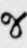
જ
